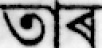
তাৰ
